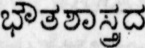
ಭೌತಶಾಸ್ತ್ರದ
